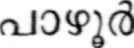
പാഴൂര്‍
